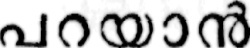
പറയാന്‍
